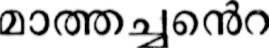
മാത്തച്ചന്റെ
